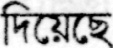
দিয়েছে
